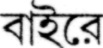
বাইরে
